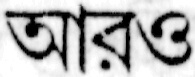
আরও
